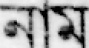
নাম
